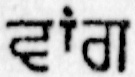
ਵਾਂਗ
